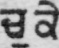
ਚੁਕੇ
